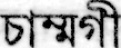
চাম্মগী
